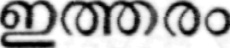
ഇത്തരം
